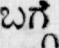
ಬಗ್ಗೆ
